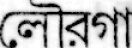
লৌরগা
